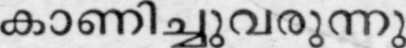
കാണിച്ചുവരുന്നു
